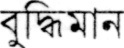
বুদ্ধিমান
